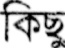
কিছু
